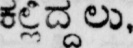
ಕಲ್ಲಿದ್ದಲು,
